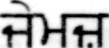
ਜੇਮਜ਼
